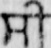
ਸੀ
